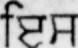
ਇਸ
